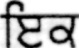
ਇਕ
